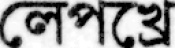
লেপখ্রে
